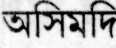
অসিমদি
